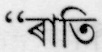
:ৰাতি
